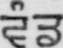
ਵੰਡ
